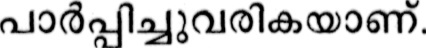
പാര്‍പ്പിച്ചുവരികയാണ്.
